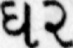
ઘર
